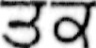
ਤਕ
